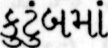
કુટુંબમાં
